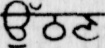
ਉੱਠਣ
